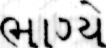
ભાગ્યે
